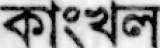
কাংখল
